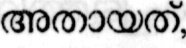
അതായത്,
